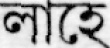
লাহে
